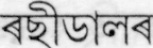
ৰছীডালৰ
